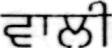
ਵਾਲੀ
